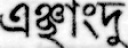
এঞ্ছাংদু
